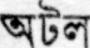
অটল
